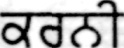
ਕਰਨੀ
